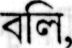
বলি,
